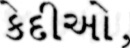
કેદીઓ,
